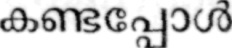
കണ്ടപ്പോള്‍
